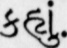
કહ્યું.
